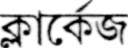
ক্লার্কেজ
